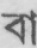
বা
